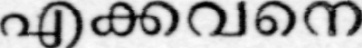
എക്കവനെ
